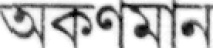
অকণমান
